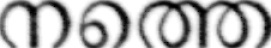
നത്തെ
